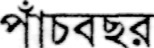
পাঁচবছর
